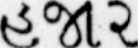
હજાર
